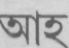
আহ
